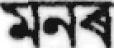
মনৰ
